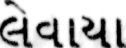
લેવાયા
